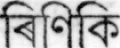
ৰিণিকি
